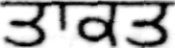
ਤਾਕਤ
